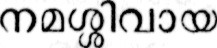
നമശ്ശിവായ
